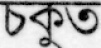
চকুত
